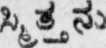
ಸ್ಮಿತ್ತನು
